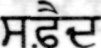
ਸਫ਼ੈਦ
